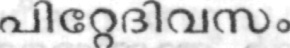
പിറ്റേദിവസം
